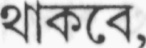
থাকবে,
